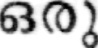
ഒരു
